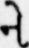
ને
